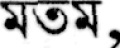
মতম,
